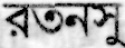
রতনসু
